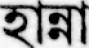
হান্না
